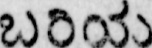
ಬರಿಯ
